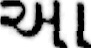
આ
